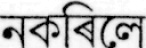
নকৰিলে
